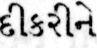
દીકરીને
